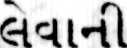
લેવાની
